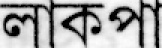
লাকপা
